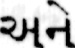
અને
